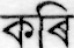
কৰি
